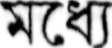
মধ্যে
